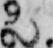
ಪಿ.
